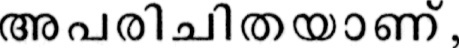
അപരിചിതയാണ്,
